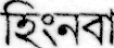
হিংনবা
